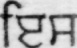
ਇਸ
